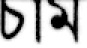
চাম
